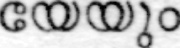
യേയും
